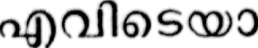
എവിടെയാ
